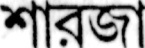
শারজা
